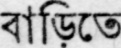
বাড়িতে
